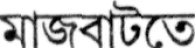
মাজবাটতে
